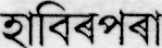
হাবিৰপৰা
